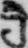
ਹੈ
